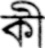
কী
